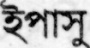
ইপাসু
